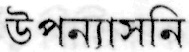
উপন্যসনি
